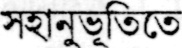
সহানুভূতিতে
